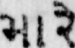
મારે
